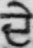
ਦੇ
